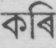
কৰি
